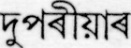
দুপৰীয়াৰ
